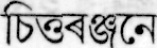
চিত্তৰঞ্জনে
